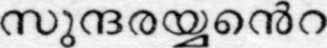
സുന്ദരയ്യന്റെ
